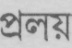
প্ৰলয়
